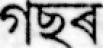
গছৰ
